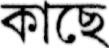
কাছে
